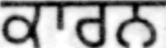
ਕਾਰਨ
